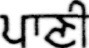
ਪਾਣੀ
